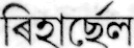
ৰিহার্ছেল
